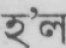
হ'ল
